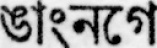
ঙাংনগে
